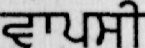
ਵਾਪਸੀ
